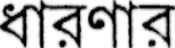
ধারণার
